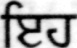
ਇਹ
